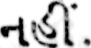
નહીં.
